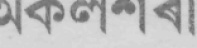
অকলশৰ
